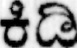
ಕಿಡಿ
